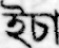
ইচা
